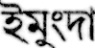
ইমুংদা
